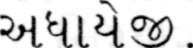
અધાયેજી.
